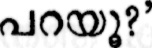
പറയൂ?’
